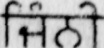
ਜਿੰਨੀ
